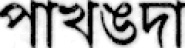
পাখঙদা
